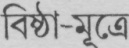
বিষ্ঠা-মূত্ৰে
